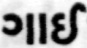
ગાઈ
